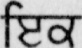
ਇਕ
